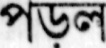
পড়ল
